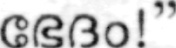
ഭേദം!”
